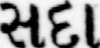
સદા
